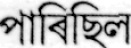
পাৰিছিল
